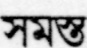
সমস্ত
